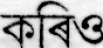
কৰিও
